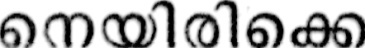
നെയിരിക്കെ
